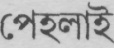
পেহলাই
